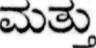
ಮತ್ತು
